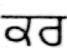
ਕਰ
